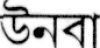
উনবা
